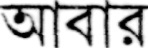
আবার
